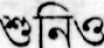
শুনিও
